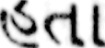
હતા
